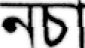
নচা
